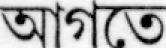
আগতে
